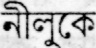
নীলুকে
